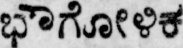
ಭೌಗೋಳಿಕ
